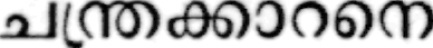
ചന്ത്രക്കാറനെ
